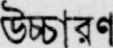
উচ্চারণ
